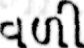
વળી
